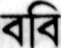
ববি
